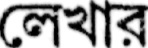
লেখার
